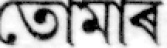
তোমাৰ
